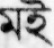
মই
